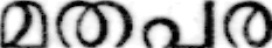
മതപര
